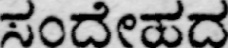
ಸಂದೇಹದ
